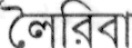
লৈরিবা
